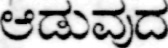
ಆಡುವುದ
